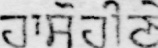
ਹਾਸੋਹੀਣੇ
